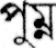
পুম্ন
